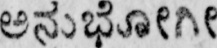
ಅನುಭೋಗೀ
